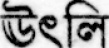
ঊৎলি
